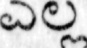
ಎಲ್ಲ
